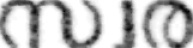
സ്വര
